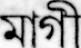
মাগী
